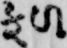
ફળ
